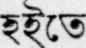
হইতে
